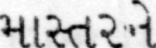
માસ્તરને
